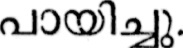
പായിച്ചു.
